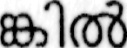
ങ്കില്‍
